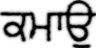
ਕਮਾਉ
